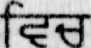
ਵਿਚ
